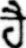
ਹੈ
